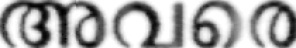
അവരെ
